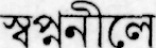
স্বপ্ননীলে
